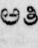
ಅತಿ
